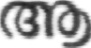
ആ
